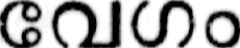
വേഗം
